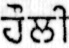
ਹੌਲੀ
